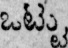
ಒಟ್ಟು
